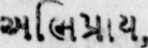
અભિપ્રાય,
